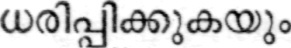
ധരിപ്പിക്കുകയും
